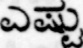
ಎಷ್ಟು
